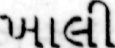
ખાલી
